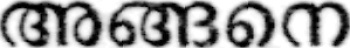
അങ്ങനെ
